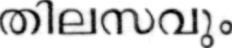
തിലസവും
